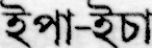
ইপা-ইচা
